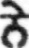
ਨੇ
